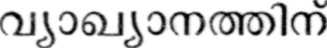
വ്യാഖ്യാനത്തിന്
